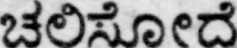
ಚಲಿಸೋದೆ
